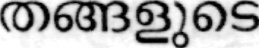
തങ്ങളുടെ
